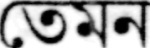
তেমন
